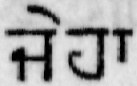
ਜੇਹਾ
